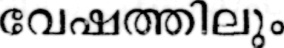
വേഷത്തിലും
